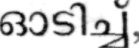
ഓടിച്ച്,
